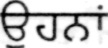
ਉਹਨਾਂ
